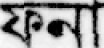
ফনা
